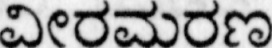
ವೀರಮರಣ
